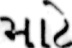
માટે
